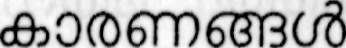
കാരണങ്ങള്‍
